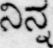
ನಿನ್ನ
